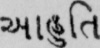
આહુતિ
